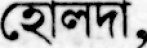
হোলদা,
